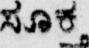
ಸೂಕ್ತ
